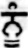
ਨੂੰ
